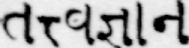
તત્તવજ્ઞાન
